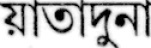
য়াতাদুনা
